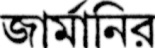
জার্মানির
